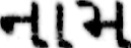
નામ
